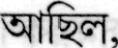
আছিল,
